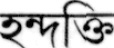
হন্দক্তি
